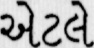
એટલે
